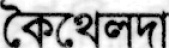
কৈথেলদা
